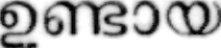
ഉണ്ടായ
